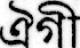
ঐগী
